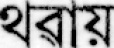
থৱায়
